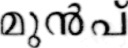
മുന്‍പ്
